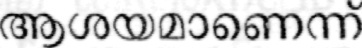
ആശയമാണെന്ന്
